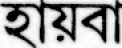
হায়বা
